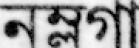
নম্লগা
